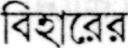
বিহারের
